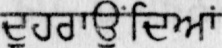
ਦੁਹਰਾਉਂਦਿਆਂ
